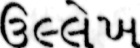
ઉલ્લેખ
